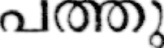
പത്തു
